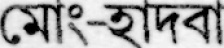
মোং-হাদবা
